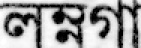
লম্নগা
